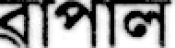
ৱাপাল
